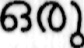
ഒരു
